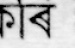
কৰি
